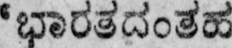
‘ಭಾರತದಂತಹ
